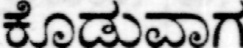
ಕೊಡುವಾಗ
